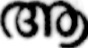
ആ
